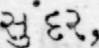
સુંદર,
